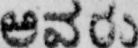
ಅವರು
